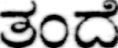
ತಂದೆ
